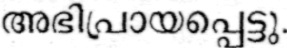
അഭിപ്രായപ്പെട്ടു.
